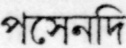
পসেনদি
